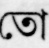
তো
